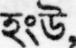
হংউ,
